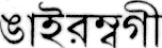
ঙাইরম্বগী
